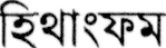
হিথাংফম
